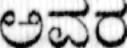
ಅವರ
